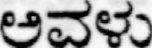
ಅವಳು
